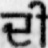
ਦੀ
